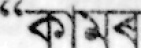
"কামৰ
